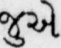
જુએ
